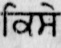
ਕਿਸੇ
